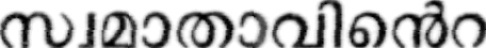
സ്വമാതാവിന്റെ
